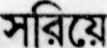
সরিয়ে
